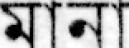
মানা
